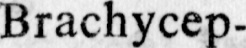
Brachycep-
